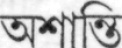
অশান্তি
